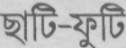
ছাটি-ফুটি
